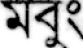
মবুং
